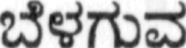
ಬೆಳಗುವ
